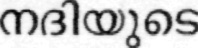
നദിയുടെ
